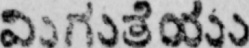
ಮಿಗುತೆಯು
